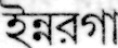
ইন্নরগা
